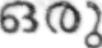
ഒരു
